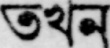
তখন
